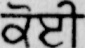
ਕੋਈ
